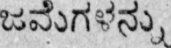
ಜಮೆಗಳನ್ನು
